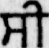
ਸੀ
